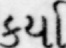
કર્યા
